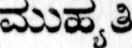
ಮುಹ್ಯತಿ
